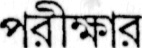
পরীক্ষার
